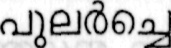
പുലര്‍ച്ചെ
